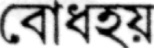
বোধহয়
